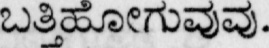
ಬತ್ತಿಹೋಗುವುವು.
